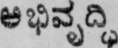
ಅಭಿವೃದ್ಧಿ
